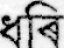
ধৰি
